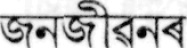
জনজীৱনৰ
